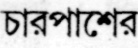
চারপাশের
